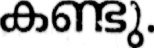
കണ്ടു.
